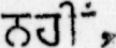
ਨਹੀਂ
